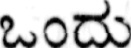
ಒಂದು
